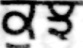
ਕੁਝ
